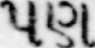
પણ
